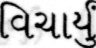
વિચાર્યું
